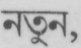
নতুন,
